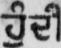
ਹੁੰਦੀ
